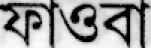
ফাওবা
